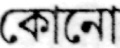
কোনো
